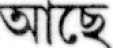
আছে
